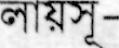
লায়সূ-
